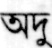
অদু
